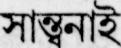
সান্ত্বনাই
